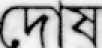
দোষ
